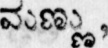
ಮಣ್ಣು,
